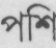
পশি
